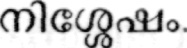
നിശ്ശേഷം.
